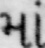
માં
